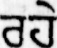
ਰਹੇ
